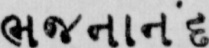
ભજનાનંદ
